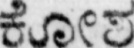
ಕೋಶ
